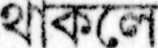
থাকলে
